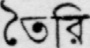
তৈরি
